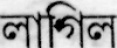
লাগিল
